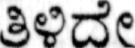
ತಿಳಿದೇ
